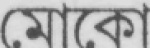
মোকো
